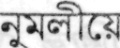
নুমলীয়ে
